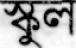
স্কুল
